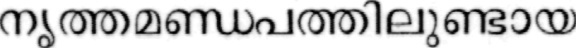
നൃത്തമണ്ഡപത്തിലുണ്ടായ
